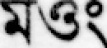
মওং
